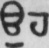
ਉਹ
